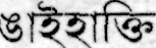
ঙাইহাক্তি
